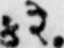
કરે.
